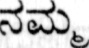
ನಮ್ಮ
